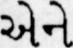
એને
